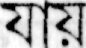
যায়
